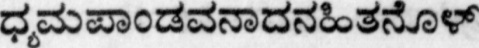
ಧ್ಯಮಪಾಂಡವನಾದನಹಿತನೊಳ್
